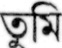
তুমি
